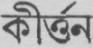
কীৰ্ত্তন
